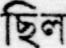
ছিল
